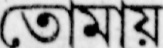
তোমায়
